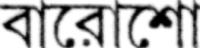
বারোশো
